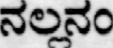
ನಲ್ಲನಂ
